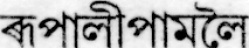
ৰূপালীপামলৈ
